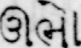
ઊભો
